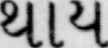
થાય
